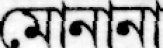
মোনানা
